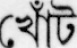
খোঁট
